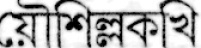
য়ৌশিল্লকখি
